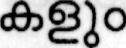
കളും
